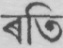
ৰতি
